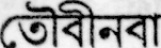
তৌবীনবা
